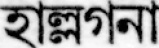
হাল্লগনা
